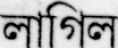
লাগিল
